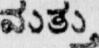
ಮತ್ತು
